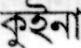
কুইনা
